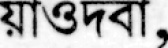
য়াওদবা,
